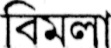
বিমলা
